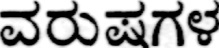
ವರುಷಗಳ
